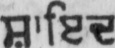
ਸ਼ਾਇਦ
